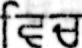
ਵਿਚ
